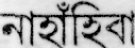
নাহাঁহিবা
